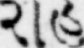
રાહ
